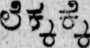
ಲೆಕ್ಕಕ್ಕೆ
